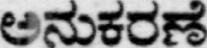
ಅನುಕರಣೆ
